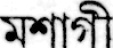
মশাগী
